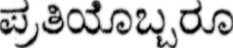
ಪ್ರತಿಯೊಬ್ಬರೂ
